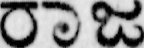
ರಾಜ
